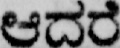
ಆದರೆ
